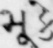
મૂકે
